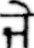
ਜੇ
